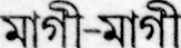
মাগী-মাগী
